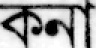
কনা
